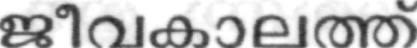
ജീവകാലത്ത്
